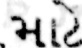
માટે
